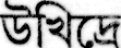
উখিদ্রে
